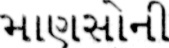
માણસોની
